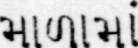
માળામાં
